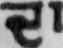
ਦਾ
